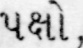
પક્ષો,
